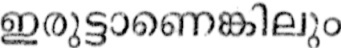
ഇരുട്ടാണെങ്കിലും
